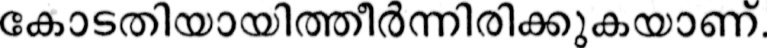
കോടതിയായിത്തീര്‍ന്നിരിക്കുകയാണ്.
